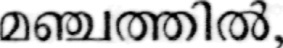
മഞ്ചത്തില്‍,
